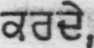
ਕਰਦੇ,
